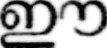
ഈ
